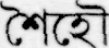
শৈহৌ
